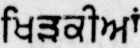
ਖਿੜਕੀਆਂ
